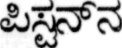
ಪಿಸ್ಟನ್‌ನ
